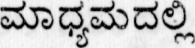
ಮಾಧ್ಯಮದಲ್ಲಿ
